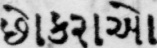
છોકરાઓ
